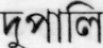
দুপালি
